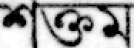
শক্তম
